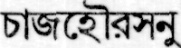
চাজহৌরসনু
